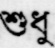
শুধু
